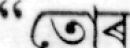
"তোৰ
